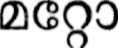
മറ്റോ
